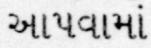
આપવામાં
